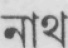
নাথ
